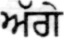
ਅੱਗੇ
